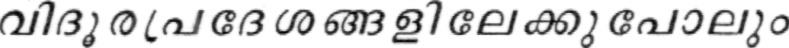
വിദൂരപ്രദേശങ്ങളിലേക്കുപോലും
